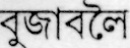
বুজাবলৈ
